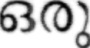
ഒരു
